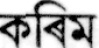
কৰিম
